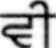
ਵੀ
